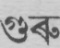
গুৰু
